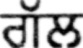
ਗੱਲ
